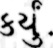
કર્યું.
